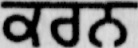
ਕਰਨ
